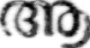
ആ
